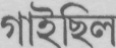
গাইছিল
